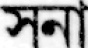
সনা
